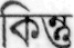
কিন্তু
